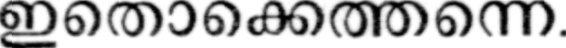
ഇതൊക്കെത്തന്നെ.
